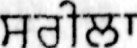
ਸਰੀਲਾ
